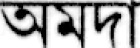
অমদা
